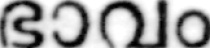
ഭാവം
